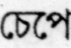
চেপে
